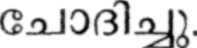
ചോദിച്ചു.
